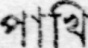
পাখি
